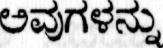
ಅವುಗಳನ್ನು
